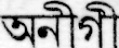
অনীগী
